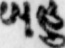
બહુ
